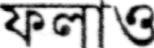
ফলাও
